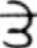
ਤੇ
